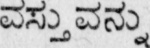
ವಸ್ತುವನ್ನು
